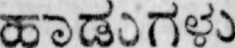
ಹಾಡುಗಳು
